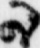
જે
